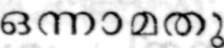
ഒന്നാമതു
